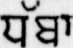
ਧੱਬਾ
